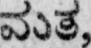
ಮತ,
